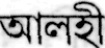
আলহী
